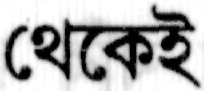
থেকেই
